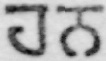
ਹਨ
